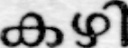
കഴി
